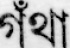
গঁথা
